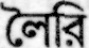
লৈরি
